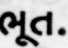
ભૂત.
